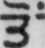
ਤੋਂ
